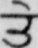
ਤੇ
